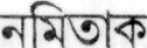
নমিতাক
